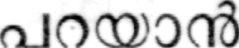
പറയാന്‍
